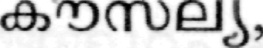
കൌസല്യ,
